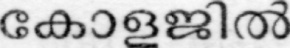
കോളജില്‍
